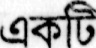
একটি
